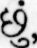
છું,
